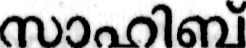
സാഹിബ്
